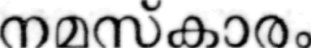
നമസ്കാരം
